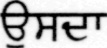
ਉਸਦਾ
